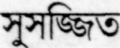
সুসজ্জিত
